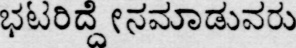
ಭಟರಿದ್ದೇನಮಾಡುವರು
